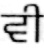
ਵੀ
